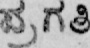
ಪ್ರಗತಿ
